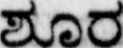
ಶೂರ
